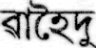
ৱাহৈদু
